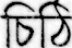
চিঠি
